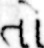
તો
